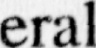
eral
